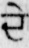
ਦੇ
